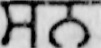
ਸਨ
